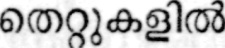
തെറ്റുകളില്‍
